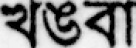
খঙবা
